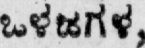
ಒಳಜಗಳ,
